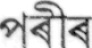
পৰীৰ
